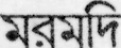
মরমদি
